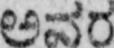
ಅವರ
